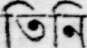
তিনি
